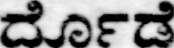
ರ್ದೊಡೆ
